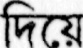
দিয়ে
